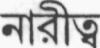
নারীত্ব
